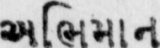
અભિમાન
